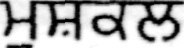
ਮੁਸ਼ਕਲ
